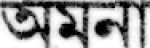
অমনা
